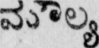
ಮೌಲ್ಯ
